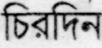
চিরদিন
